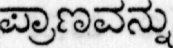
ಪ್ರಾಣವನ್ನು
